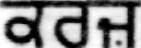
ਕਰਜ਼
